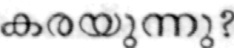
കരയുന്നു?
